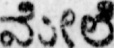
ಮೇಲೆ
